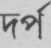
দৰ্প
